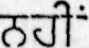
ਨਹੀਂ
